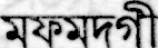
মফমদগী
